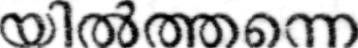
യില്‍ത്തന്നെ
